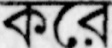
করে
